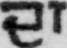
ਦਾ
